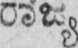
ರಾಜ್ಯ
